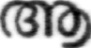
ആ
